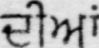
ਦੀਆਂ
